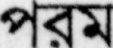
পরম
